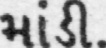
માંડી.
